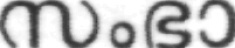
സംഭാ
